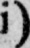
i)
